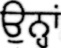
ਉਨ੍ਹਾਂ
